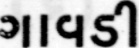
ગાવડી
